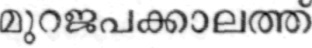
മുറജപക്കാലത്ത്
